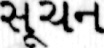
સૂચન
